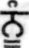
ਨੂੰ
